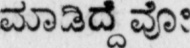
ಮಾಡಿದ್ದೆವೋ
